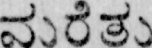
ಮರೆತು
